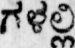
ಗಳಲ್ಲಿ
